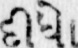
દીઘો
